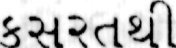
કસરતથી
